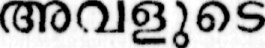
അവളുടെ
